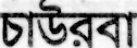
চাউরবা
